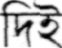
দিই
